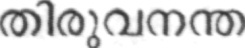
തിരുവനന്ത
